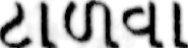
ટાળવા
